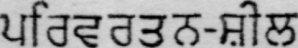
ਪਰਿਵਰਤਨ-ਸ਼ੀਲ
